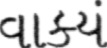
વાક્યં
